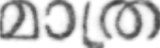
മാത്ര
